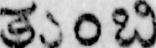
ತುಂಬಿ
